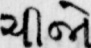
ચીજો
